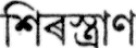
শিৰস্ত্রাণ
